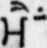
ਮੈਂ
